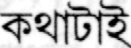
কথাটাই
